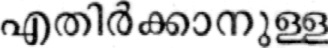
എതിര്‍ക്കാനുള്ള
